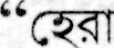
“হেরা
